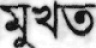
মুখত
